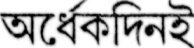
অর্ধেকদিনই
